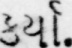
કર્યા.
